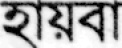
হায়বা
